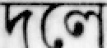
দলে
